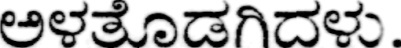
ಅಳತೊಡಗಿದಳು.
